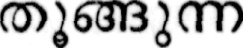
തൂങ്ങുന്ന
